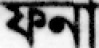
ফনা
